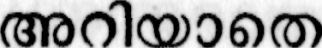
അറിയാതെ
